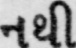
નથી
